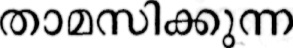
താമസിക്കുന്ന
